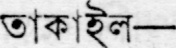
তাকাইল—
